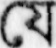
যে
